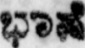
ಭಾಷೆ
